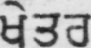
ਖੇਤਰ
